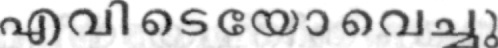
എവിടെയോവെച്ചു
